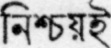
নিশ্চয়ই
